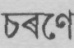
চৰণে
